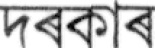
দৰকাৰ
